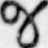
જ
